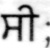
ਸੀ;
